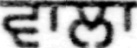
ਵਾਲਾ
